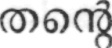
തന്റെ
